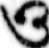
ও
